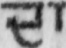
ਦਾ
